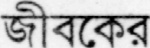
জীবকের
